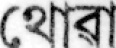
থোৱা
